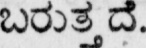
ಬರುತ್ತದೆ.
